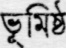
ভূমিষ্ঠ
